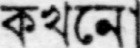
কখনো
